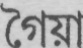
গৈয়া
